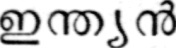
ഇന്ത്യന്‍
